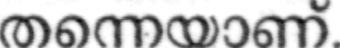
തന്നെയാണ്.
